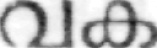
വക
